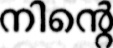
നിന്റെ
